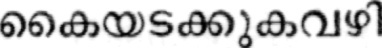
കൈയടക്കുകവഴി
